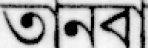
তানবা
